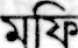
মফি
